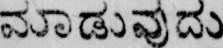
ಮಾಡುವುದು
